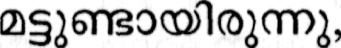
മട്ടുണ്ടായിരുന്നു,
